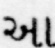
આ
